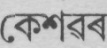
কেশৱৰ
